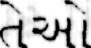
તેઓ
